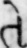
તે
